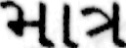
માત્ર
